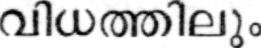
വിധത്തിലും
